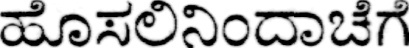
ಹೊಸಲಿನಿಂದಾಚೆಗೆ
